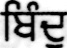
ਬਿੰਦੁ
